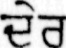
ਦੇਰ
